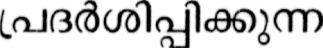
പ്രദര്‍ശിപ്പിക്കുന്ന
